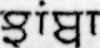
ਝਾਂਬਾ
